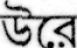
উরে
